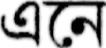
এনে
